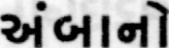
અંબાનો
